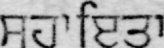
ਸਹਾਇਤਾ
